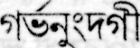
গর্ভনুংদগী
